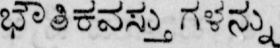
ಭೌತಿಕವಸ್ತುಗಳನ್ನು
